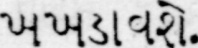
ખખડાવશે.
